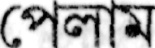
পেলাম
